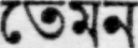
তেমন
